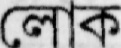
লোক
